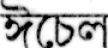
ঈচেল
